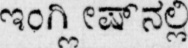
ಇಂಗ್ಲೀಷ್‌ನಲ್ಲಿ
